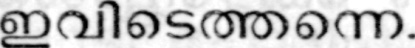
ഇവിടെത്തന്നെ.
